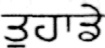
ਤੁਹਾਡੇ
